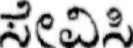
ಸೇವಿಸಿ
